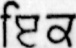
ਇਕ
